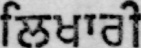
ਲਿਖਾਰੀ
